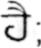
ਹੈ;
